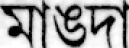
মাঙদা
